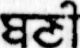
ਬਣੀ
